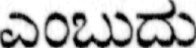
ಎಂಬುದು
